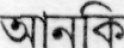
আনকি
